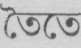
তৈতে
